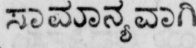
ಸಾಮಾನ್ಯವಾಗಿ
